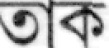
তাক
